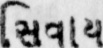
સિવાય
